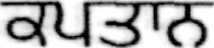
ਕਪਤਾਨ
